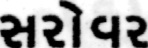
સરોવર
